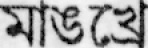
মাঙখ্রে
